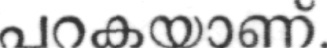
പറകയാണ്.
